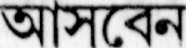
আসবেন
